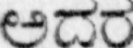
ಅದರ
